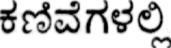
ಕಣಿವೆಗಳಲ್ಲಿ
